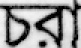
চরা
